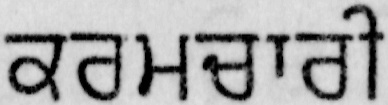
ਕਰਮਚਾਰੀ
